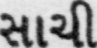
સાચી
